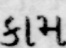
કામ
